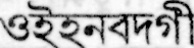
ওইহনবদগী
